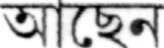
আছেন
